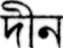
দীন
